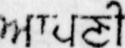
ਆਪਣੀ
